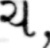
ચ,
